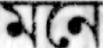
মনে
